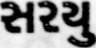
સરયુ
